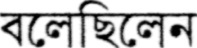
বলেছিলেন
